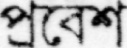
প্রবেশ
